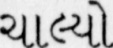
ચાલ્યો
